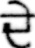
ਦੇ
